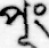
পূং
